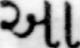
આ
